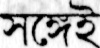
সঙ্গেই
